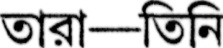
তারা-তিনি
